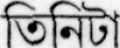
তিনিটা
